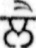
ਲੈ
